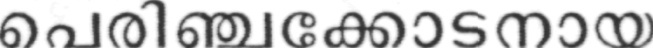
പെരിഞ്ചക്കോടനായ
